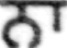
ਨਾ
